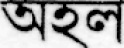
অহল
